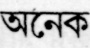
অনেক
